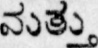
ಮತ್ತು
